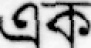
এক
